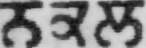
ਨਕਲ
